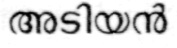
അടിയന്‍
